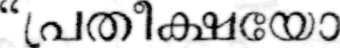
"പ്രതീക്ഷയോ
